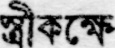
স্ত্রীকক্ষে
